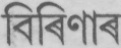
বিৰিণাৰ
